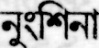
নুংশিনা
